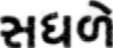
સધળે
